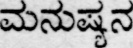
ಮನುಷ್ಯನ
